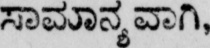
ಸಾಮಾನ್ಯವಾಗಿ,
